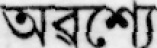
অৱশ্যে
